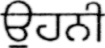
ਉਹਨੀ
